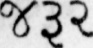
જરૂર
